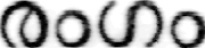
രംഗം
